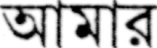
আমার
